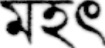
মহত্
